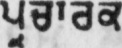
ਪ੍ਰਚਾਰਕ
